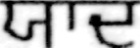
ਯਾਦ
